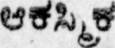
ಆಕಸ್ಮಿಕ
